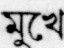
মুখে
